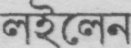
লইলেন
